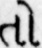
તો
